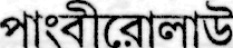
পাংবীরোলাউ
